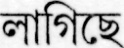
লাগিছে
